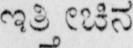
ಇತ್ತೀಚಿನ
